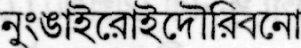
নুংঙাইরোইদৌরিবনো
